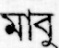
মাবু
